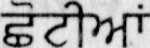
ਛੋਟੀਆਂ
